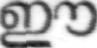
ഈ
